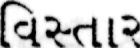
વિસ્તાર
